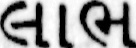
લાભ
